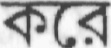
করে
